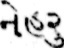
નેહરુ
